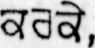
ਕਰਕੇ,
